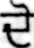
ਦੋ
